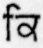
ਕਿ
